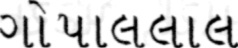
ગોપાલલાલ
